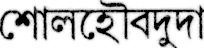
শোলহৌবদুদা
